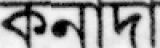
কনাদা
